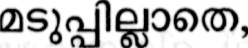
മടുപ്പില്ലാതെ,
